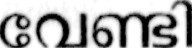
വേണ്ടി
